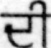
ਦੀ
